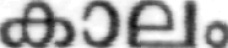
കാലം
